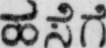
ಹಸೆಗೆ
